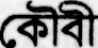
কৌবী
